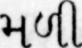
મળી
